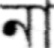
না
